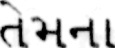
તેમના
